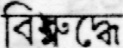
বিরুদ্ধে
